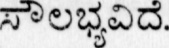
ಸೌಲಭ್ಯವಿದೆ.
